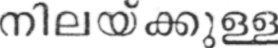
നിലയ്ക്കുള്ള
